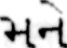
મને
